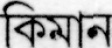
কিমান
